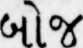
બોજ
